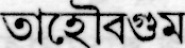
তাহৌবগুম
